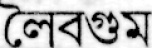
লৈবগুম
